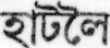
হাটলৈ
